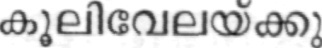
കൂലിവേലയ്ക്കു
